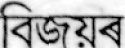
বিজয়ৰ
